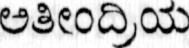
ಅತೀಂದ್ರಿಯ
